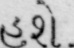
હશે.
